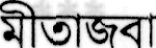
মীতাজবা
